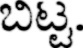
ಬಿಟ್ಟ.
